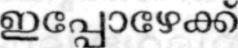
ഇപ്പോഴേക്ക്
